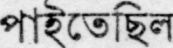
পাইতেছিল
